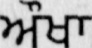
ਔਖਾ
